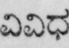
ವಿವಿಧ
